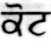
ਕੋਟ
